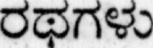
ರಥಗಳು
